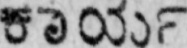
ಕಾರ್ಯ
